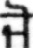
ਜੋ
